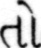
તો
